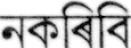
নকৰিবি
